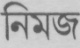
নিমজ
